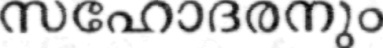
സഹോദരനും
